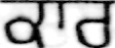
ਕਾਰ
